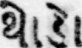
થોડો
